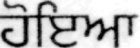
ਹੋਇਆ
